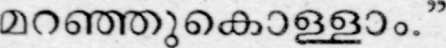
മറഞ്ഞുകൊള്ളാം."
